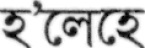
হ'লেহে
